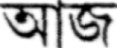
আজ
